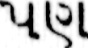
પણ
